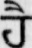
ਹੈ
